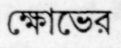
ক্ষোভের
